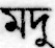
মদু
